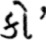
કો
